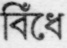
বিঁধে
